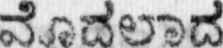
ಮೊದಲಾದ
